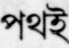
পথই
